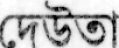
দেউতা
